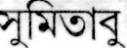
সুমিতাবু
